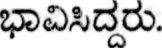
ಭಾವಿಸಿದ್ದರು.
